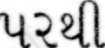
પરથી
